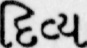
દિવ્ય
